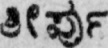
ತೀರ್ಪು
